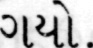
ગયો.
